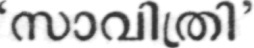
‘സാവിത്രി'
